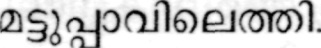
മട്ടുപ്പാവിലെത്തി.
